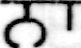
ਨਾ
